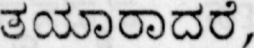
ತಯಾರಾದರೆ,
